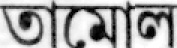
তামোল
